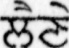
ਲੈਣੇ
